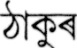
ঠাকুৰ
